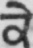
ਕੇ
